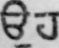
ਉਹ
